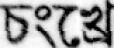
চংখ্রে
